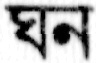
ঘন
